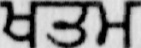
ਖਤਮ
